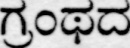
ಗ್ರಂಥದ
